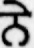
ਨੇ
